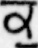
ਕੁ
